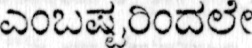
ಎಂಬಷ್ಟರಿಂದಲೇ
